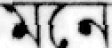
মনে
